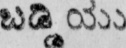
ಬಡ್ಡಿಯು
